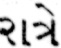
રાત્રે
